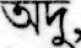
অদু
